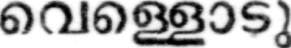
വെള്ളൊടു
